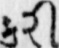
કરી
